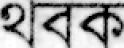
থবক
